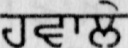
ਹਵਾਲੇ
